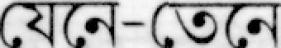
যেনে-তেনে
